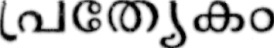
പ്രത്യേകം
